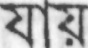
যায়
